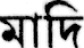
মাদি
